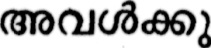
അവള്‍ക്കു
